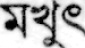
মখুৎ
